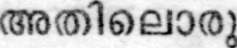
അതിലൊരു
